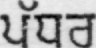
ਪੱਧਰ
